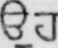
ਉਹ
